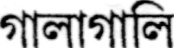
গালাগালি
